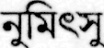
নুমিৎসু
